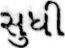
સુધી
